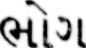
ભોગ
